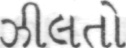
ઝીલતો
